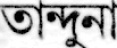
তান্দুনা
